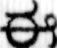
ಈ
